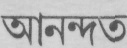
আনন্দত
